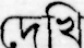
দেখি
